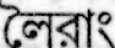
লৈরাং
